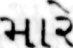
મારે
